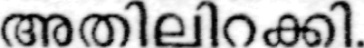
അതിലിറക്കി.
